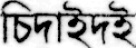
চিদাইদই
